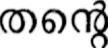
തന്റെ
